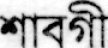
শাবগী
